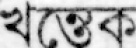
খন্তেক
